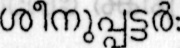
ശീനുപ്പട്ടര്‍:
